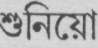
শুনিয়ো
